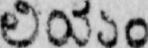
ಲಿಯಂ
